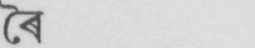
ৰৈ
